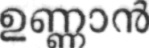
ഉണ്ണാന്‍
